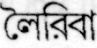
লৈরিবা
